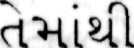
તેમાંથી
